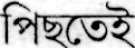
পিছতেই
